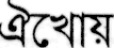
ঐখোয়
